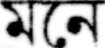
মনে
